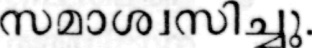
സമാശ്വസിച്ചു.
